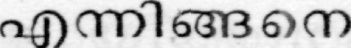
എന്നിങ്ങനെ
